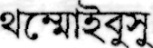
থম্মোইবুসু
